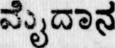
ಮೈದಾನ
